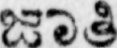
ಜಾತಿ
